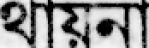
থায়না
